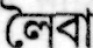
লৈবা
